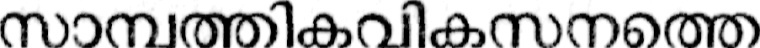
സാമ്പത്തികവികസനത്തെ
